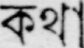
কথা
